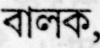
বালক,
